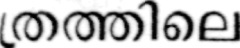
ത്രത്തിലെ
